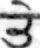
ਤੇ
